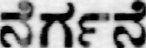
ನೆರ್ಗನೆ
